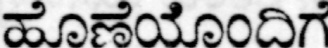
ಹೊಣೆಯೊಂದಿಗೆ
